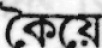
কৈয়ে
